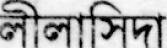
লীলাসিদা
